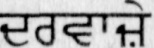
ਦਰਵਾਜ਼ੇ
